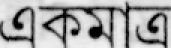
একমাত্র
